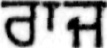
ਰਾਜ
